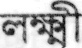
লক্ষ্মী
